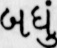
બધું
